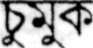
চুমুক
